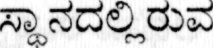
ಸ್ಥಾನದಲ್ಲಿರುವ
